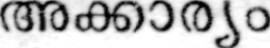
അക്കാര്യം
